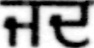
ਜਦ
